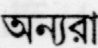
অন্যরা
